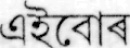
এইবোৰ
